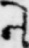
ને
